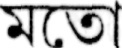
মতো
